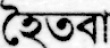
হৈতবা
